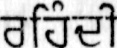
ਰਹਿੰਦੀ
